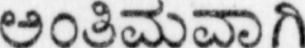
ಅಂತಿಮವಾಗಿ
